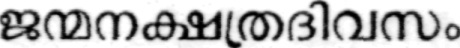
ജന്മനക്ഷത്രദിവസം
